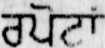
ਰਪੋਟਾਂ
